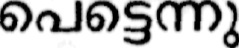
പെട്ടെന്നു
